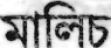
মালিচ
